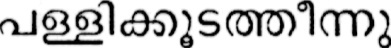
പള്ളിക്കൂടത്തീന്നു
